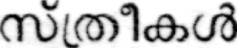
സ്ത്രീകള്‍
